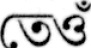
তেওঁ
